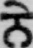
ਨੇ
